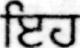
ਇਹ
